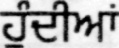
ਹੁੰਦੀਆਂ
